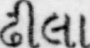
ઢીલા
